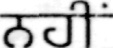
ਨਹੀਂ
